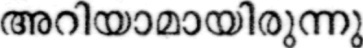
അറിയാമായിരുന്നു
